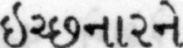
ઈચ્છનારને
